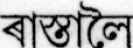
ৰাস্তালৈ
